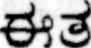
ಈತ
